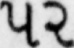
પર
